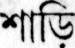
শাড়ি
